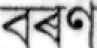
বৰণ
